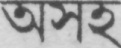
অসহ
